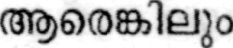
ആരെങ്കിലും
